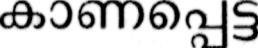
കാണപ്പെട്ട
